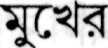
মুখের
